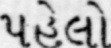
પહેલો
